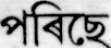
পৰিছে
